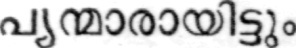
പ്യന്മാരായിട്ടും
